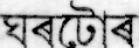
ঘৰটোৰ
